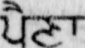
ਪੈਣਾ
